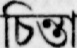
চিন্তা
